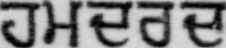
ਹਮਦਰਦ
